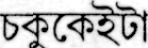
চকুকেইটা
